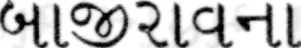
બાજીરાવના
